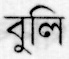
বুলি
